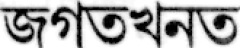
জগতখনত
